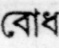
বোধ
